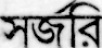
সর্জরি
